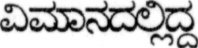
ವಿಮಾನದಲ್ಲಿದ್ದ
